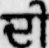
ਦੀ
